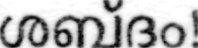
ശബ്ദം!
